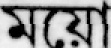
ময়ো
